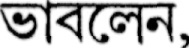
ভাবলেন,
